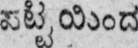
ಪಟ್ಟಿಯಿಂದ
